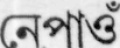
নেপাওঁ
